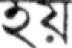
হয়
